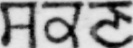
ਸਕਣ
